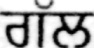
ਗੱਲ
